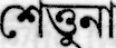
শেত্তুনা
